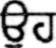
ਉਹ
